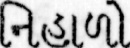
નિહાળો
